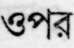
ওপর
